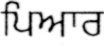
ਪਿਆਰ
